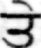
ਤੇ
